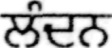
ਲੰਦਨ
